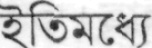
ইতিমধ্যে
